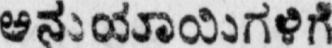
ಅನುಯಾಯಿಗಳಿಗೆ
